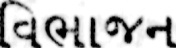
વિભાજન
